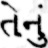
તેનું
